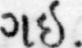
ગઈ.
